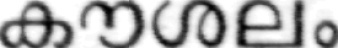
കൌശലം
